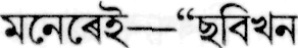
মনেৰেই-"ছবিখন
